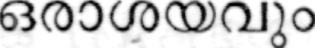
ഒരാശയവും
